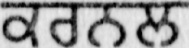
ਕਰਨਲ
